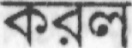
করল
